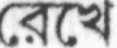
রেখে
